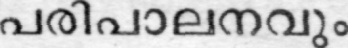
പരിപാലനവും
